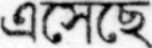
এসেছে
